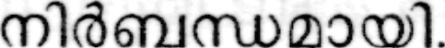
നിര്‍ബന്ധമായി.
